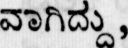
ವಾಗಿದ್ದು,
